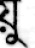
য়ু
